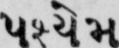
પશ્યેમ
